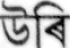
উৰি
